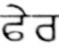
ਫੇਰ
